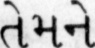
તેમને
